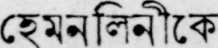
হেমনলিনীকে
